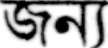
জন্য
